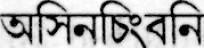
অসিনচিংবনি
